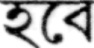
হবে
